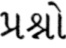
પ્રશ્નો
